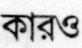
কারও
